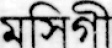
মসিগী
